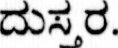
ದುಸ್ತರ.
